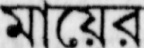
মায়ের
